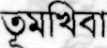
তূমখিবা
